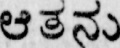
ಆತನು
